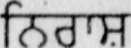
ਨਿਰਾਸ਼
